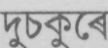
দুচকুৰে
